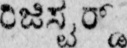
ರಿಜಿಸ್ಟರ್‍ಡ್
